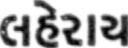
લહેરાય
